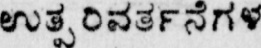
ಉತ್ಪರಿವರ್ತನೆಗಳ
